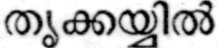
തൃക്കയ്യില്‍
